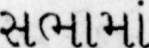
સભામાં
